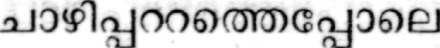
ചാഴിപ്പററത്തെപ്പോലെ
